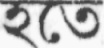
হতে
